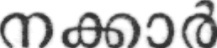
നക്കാര്‍
